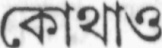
কোথাও
